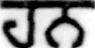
ਹਨ
